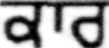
ਕਾਰ
